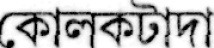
কোলকটাদা
